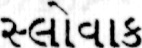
સ્લોવાક
